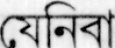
যেনিবা
